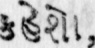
કહેશો,
